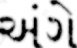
અંગે
